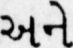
અને
